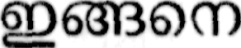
ഇങ്ങനെ
